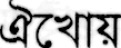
ঐখোয়
